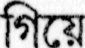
গিয়ে
